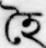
হৈ
